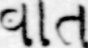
વાત
